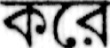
করে
